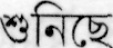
শুনিছে
